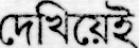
দেখিয়েই
